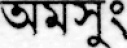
অমসুং
